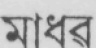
মাধৱ
